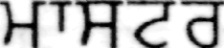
ਮਾਸਟਰ
